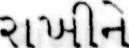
રાખીને
